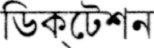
ডিক্টেশন
